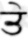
ਤੇ
